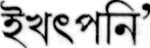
ইখৎপনি’
